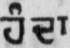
ਹੁੰਦਾ
